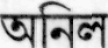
অনিল
